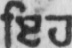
ਇਹ
